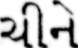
ચીને
